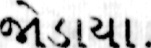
જોડાયા.
